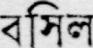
বসিল
